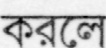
করলে
